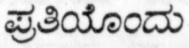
ಪ್ರತಿಯೊಂದು
